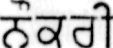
ਨੌਕਰੀ
